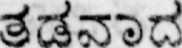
ತಡವಾದ
